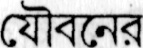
যৌবনের
